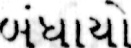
બંધાયો
